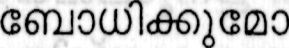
ബോധിക്കുമോ
